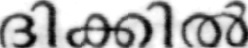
ദിക്കില്‍
